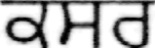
ਕਸਰ
